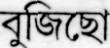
বুজিছো
